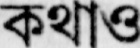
কথাও
